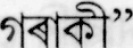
গৰাকী"
